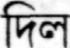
দিল
